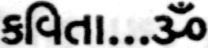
કવિતા.......ૐ
